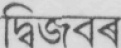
দ্বিজবৰ
